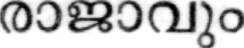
രാജാവും
